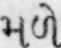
મળે
